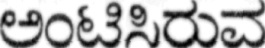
ಅಂಟಿಸಿರುವ
